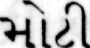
મોટી
